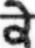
ਕੇ
